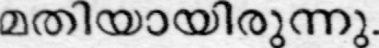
മതിയായിരുന്നു.
